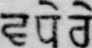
ਵਧੇਰੇ
